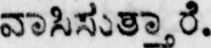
ವಾಸಿಸುತ್ತಾರೆ.
